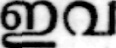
ഇവ
